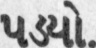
પડ્યો.
